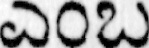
ಎಂಬ
